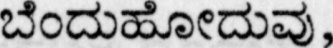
ಬೆಂದುಹೋದವು,
